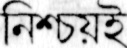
নিশ্চয়ই
